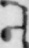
ને
